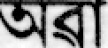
অৱা
